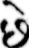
છે
